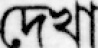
দেখা
